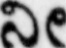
ನೀ
